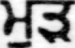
ਮੁੜ
